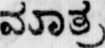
ಮಾತ್ರ
